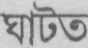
ঘাটত
